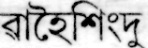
ৱাহৈশিংদু
